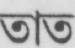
তাত
